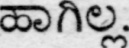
ಹಾಗಿಲ್ಲ.
